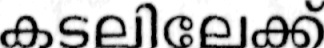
കടലിലേക്ക്
